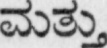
ಮತ್ತು
